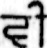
ਵੀ
